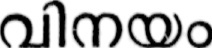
വിനയം
